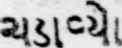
ચડાવ્યો
